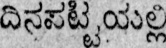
ದಿನಪಟ್ಟಿಯಲ್ಲಿ
